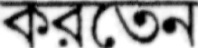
করতেন
